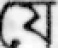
যে
